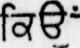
ਕਿਉਂ
